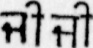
ਜੀਜੀ
